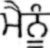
ਮੈਨੂੰ
